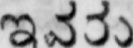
ಇವರು
